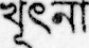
খূৎনা
